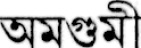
অমগুমী
